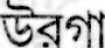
উরগা
